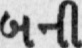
બની
